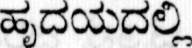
ಹೃದಯದಲ್ಲಿ
